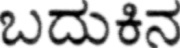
ಬದುಕಿನ
